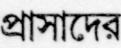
প্রাসাদের
